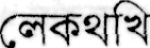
লেখথখি
